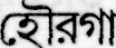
হৌরগা
